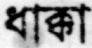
ধাক্কা
